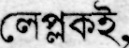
লেপ্লকই,
